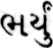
ભર્યું
